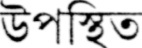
উপস্থিত
